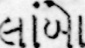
લાંબો
